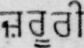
ਜ਼ਰੂਰੀ
